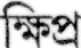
ক্ষিপ্র
